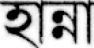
হান্না
